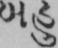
બહુ
